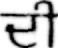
ਦੀ
